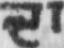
ਦਾ
